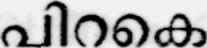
പിറകെ
